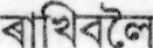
ৰাখিবলৈ
